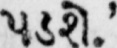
પડશે.'
